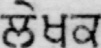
ਲੇਖਕ
